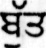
ਬੁੱਤ
